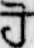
ਹੋ
